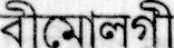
বীমোলগী
